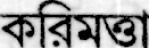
করিমত্তা
